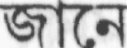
জানে
